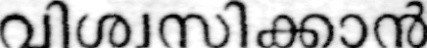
വിശ്വസിക്കാന്‍
